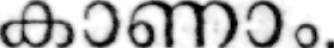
കാണാം.
